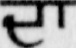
ਦਾ
